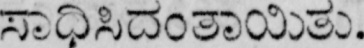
ಸಾಧಿಸಿದಂತಾಯಿತು.
